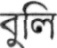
বুলি
